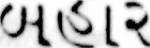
બહાર
